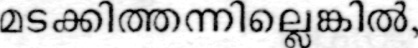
മടക്കിത്തന്നില്ലെങ്കില്‍,
